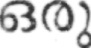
ഒരു
